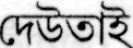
দেউতাই
